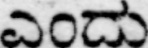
ಎಂದು
